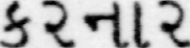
કરનાર
